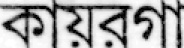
কায়রগা
